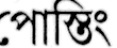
পোস্তিং
